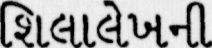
શિલાલેખની
